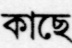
কাছে
